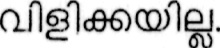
വിളിക്കയില്ല.
